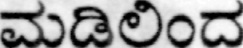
ಮಡಿಲಿಂದ
